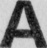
A
